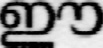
ഈ
